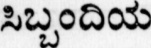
ಸಿಬ್ಬಂದಿಯ
